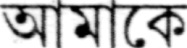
আমাকে
